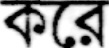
করে
